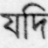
যদি
